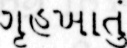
ગૃહખાતું
